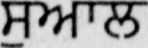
ਸੁਆਲ
